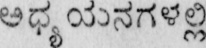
ಅಧ್ಯಯನಗಳಲ್ಲಿ
